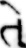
તે
